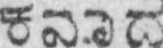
ಕವಾದ
